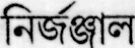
নিৰ্জঞ্জাল
